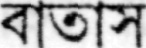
বাতাস
